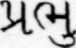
પ્રભુ
